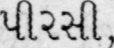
પીરસી,
